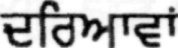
ਦਰਿਆਵਾਂ
